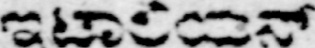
ಇಟಾಲಿಯನ್
